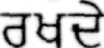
ਰਖਦੇ
